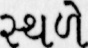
સ્થળે
